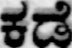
ಕಡೆ
